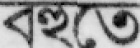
বহুতে
